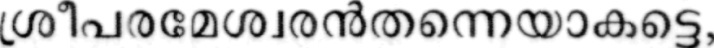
ശ്രീപരമേശ്വരന്‍തന്നെയാകട്ടെ,
